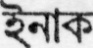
ইনাক
